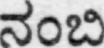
ನಂಬಿ
